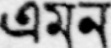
এমন
